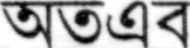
অতএব
